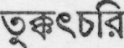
তুক্কৎচরি
